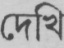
দেখি
